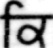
ਕਿ
